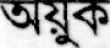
অয়ুক
